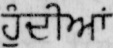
ਹੁੰਦੀਆਂ
